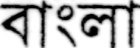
বাংলা
